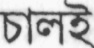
চালই
